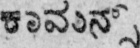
ಕಾಮನ್ಸ್
